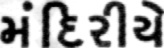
મંદિરીયે
